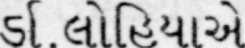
ર્ડા.લોહિયાએ
